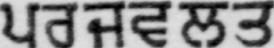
ਪਰਜਵਲਤ
